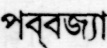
পব্বজ্যা
